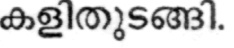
കളിതുടങ്ങി.
